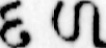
દળ
